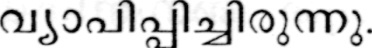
വ്യാപിപ്പിച്ചിരുന്നു.
